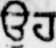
ਉਹ
